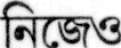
নিজেও
